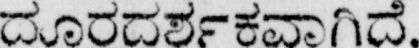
ದೂರದರ್ಶಕವಾಗಿದೆ.
